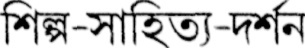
'শিল্প-সাহিত্য-দর্শন
